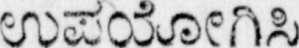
ಉಪಯೋಗಿಸಿ
